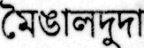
মৈঙালদুদা
